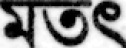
মতৎ
